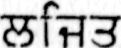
ਲਜਿਤ
